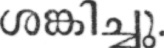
ശങ്കിച്ചു.
